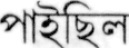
পাইছিল
